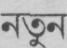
নতুন
